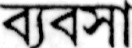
ব্যবসা
